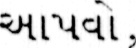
આપવો,
